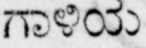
ಗಾಳಿಯ
